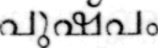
പുഷ്പം
